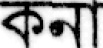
কনা
